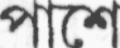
পাশে
